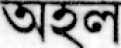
অহল
